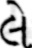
લે
